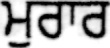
ਮੁਰਾਰ
